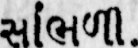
સાંભળી.
